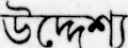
উদ্দেশ্য
